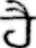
ਹੈ
